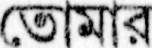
তোমার
